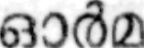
ഓര്‍മ
